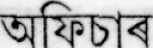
অফিচাৰ
